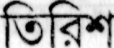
তিরিশ
